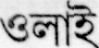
ওলাই
